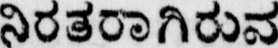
ನಿರತರಾಗಿರುವ
